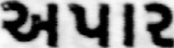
અપાર
